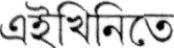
এইখিনিতে
